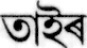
তাইৰ
